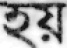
হয়
